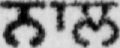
ਨਾਲ
